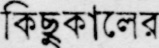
কিছুকালের
